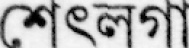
শেৎলগা
